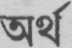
অৰ্থ
